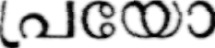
പ്രയോ
